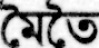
মৈতৈ
